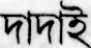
দাদাই
